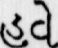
હવે
